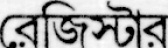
রেজিস্টার
